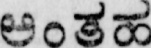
ಅಂತಹ
